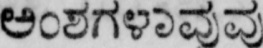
ಅಂಶಗಳಾವುವು
